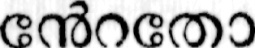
ന്റേതോ
